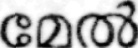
മേല്‍
